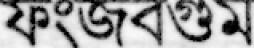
ফংজবগুম
